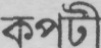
কপটী
